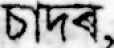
চাদৰ,
